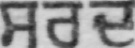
ਸਰਦ
